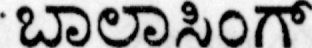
‘ಬಾಲಾಸಿಂಗ್
